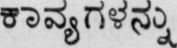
ಕಾವ್ಯಗಳನ್ನು
